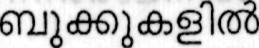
ബുക്കുകളില്‍
